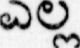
ಎಲ್ಲ
